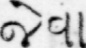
જેવા
